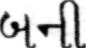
બની
